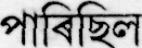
পাৰিছিল
